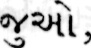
જુઓ,
